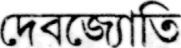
দেবজ্যোতি
